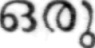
ഒരു
